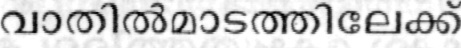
വാതില്‍മാടത്തിലേക്ക്
